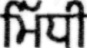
ਮਿੱਧੀ
